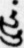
હું
